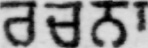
ਰਚਨਾ
